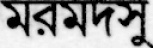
মরমদসু
